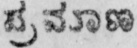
ಪ್ರಮಾಣ
